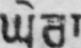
ਘੇਰਾ
